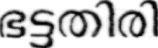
ഭട്ടതിരി
